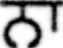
ਨਾ
